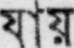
যায়
